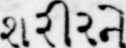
શરીરને
